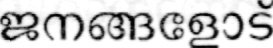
ജനങ്ങളോട്
